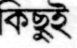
কিছুই
